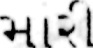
મારી
